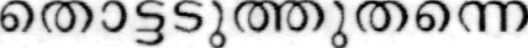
തൊട്ടടുത്തുതന്നെ
